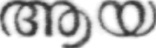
ആയ
